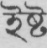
ইষ্ট
